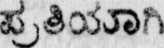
ಪ್ರತಿಯಾಗಿ
